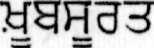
ਖ਼ੂਬਸੂਰਤ
